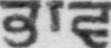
ਭਾਵ
